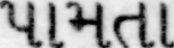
પામતા
